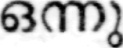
ഒന്നു
